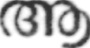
ആ
